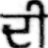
ਦੀ
